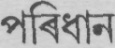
পৰিধান
